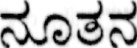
ನೂತನ
